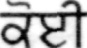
ਕੋਈ
